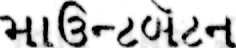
માઉન્ટબૅટન
